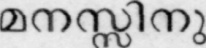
മനസ്സിനു
